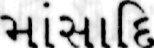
માંસાદિ
